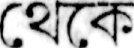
থেকে
